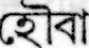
হৌবা
